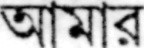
আমার
